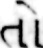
તો
